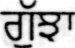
ਗੁੱਝਾ
